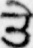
ਤੇ
